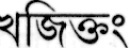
খজিক্তং
